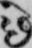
છે
